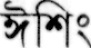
ঈশিং
